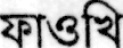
ফাওখি
